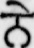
ਨੇ
